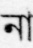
না
